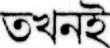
তখনই
